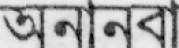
অনানবা
